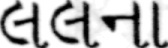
લલના
